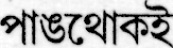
পাঙথোকই
